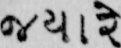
જ્યારે
